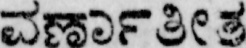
ವರ್ಣಾತೀತ
